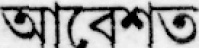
আবেশত
